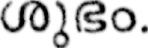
ശുഭം.
